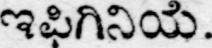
ಇಫಿಗಿನಿಯೆ.
